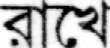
রাখে
